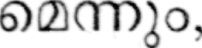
മെന്നും,
